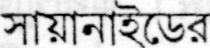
সায়ানাইডের
